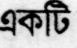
একটি
